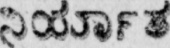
ನಿರ್ಯಾತ
